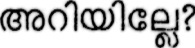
അറിയില്ലേ?
